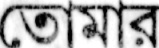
তোমার
